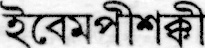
ইবেমপীশক্কী
